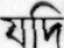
যদি
